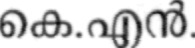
കെ.എന്‍.
